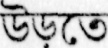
উড়তে
